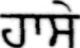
ਹਾਸੇ
